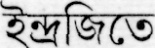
ইন্দ্রজিতে
